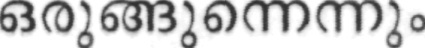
ഒരുങ്ങുന്നെന്നും
